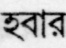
হবার
